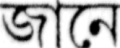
জানে
